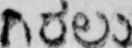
ಗಿರಲು
